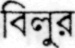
বিলুর
